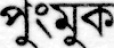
পুংমুক
